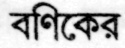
বণিকের
